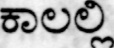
ಕಾಲಲ್ಲಿ
